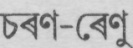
চৰণ-ৰেণু
